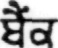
ਬੈਂਕ
